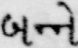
બન્ને
